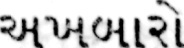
અખબારો
